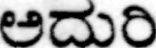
ಅದುರಿ
